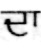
ਦਾ
